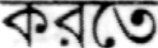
করতে
